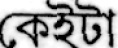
কেইটা
